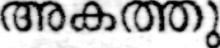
അകത്തു
